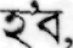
হ'ব,
